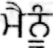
ਮੈਨੂੰ
